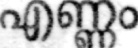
എണ്ണം
